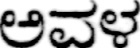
ಅವಳ
